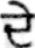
ਦੇ
